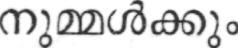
നുമ്മള്‍ക്കും
